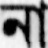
না
